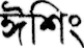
ঈশিং
